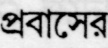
প্রবাসের
